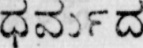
ಧರ್ಮದ
